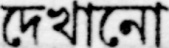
দেখানো
